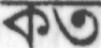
কত
